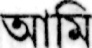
আমি
